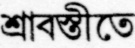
শ্রাবস্তীতে
